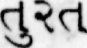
તુરત
